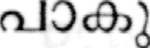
പാകു
